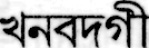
খনবদগী
